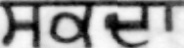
ਸਕਦਾ
